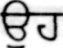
ਉਹ
